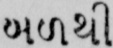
બળથી
